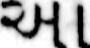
આ
